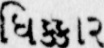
ધિક્કાર
